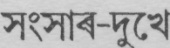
সংসাৰ-দুখে
